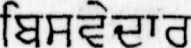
ਬਿਸਵੇਦਾਰ
